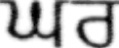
ਘਰ
